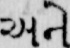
અને
